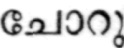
ചോറു
